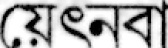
য়েৎনবা
